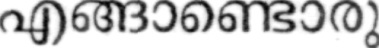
എങ്ങാണ്ടൊരു
